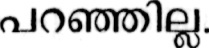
പറഞ്ഞില്ല.
